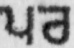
ਪਰ
